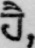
ਹੈ,
